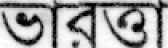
ভারত্তা
